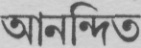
আনন্দিত
